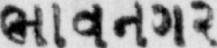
ભાવનગર
